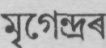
মৃগেন্দ্ৰৰ
